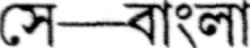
সে–বাংলা
